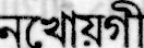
নখোয়গী
